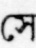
সে
